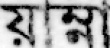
য়াম্না
